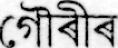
গৌৰীৰ
